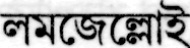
লমজেল্লোই
